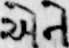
એને
